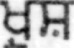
ਖ਼ੁਸ਼
